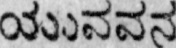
ಯುವವನ
